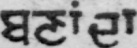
ਬਣਾਂਦਾ
